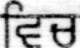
ਵਿਚ
